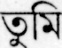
তুমি
